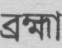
ব্ৰহ্মা
